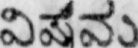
ವಿಷಮ
